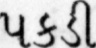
પકડી
